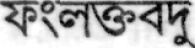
ফংলক্তবদু
